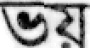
ভয়
